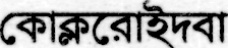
কোক্লরোইদবা
